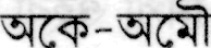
অকে-অমৌ
